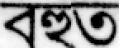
বহুত
